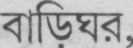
বাড়িঘর,
